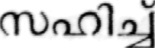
സഹിച്ച്
